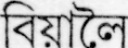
বিয়ালৈ
